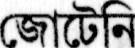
জোটেনি
